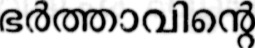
ഭര്‍ത്താവിന്റെ
